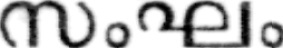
സംഘം
